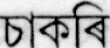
চাকৰি
